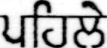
ਪਹਿਲੇ
